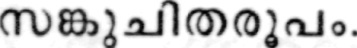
സങ്കുചിതരൂപം.
